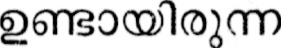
ഉണ്ടായിരുന്ന
